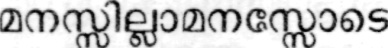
മനസ്സില്ലാമനസ്സോടെ
